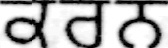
ਕਰਨ
